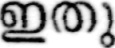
ഇതു
